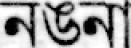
নঙনা
